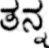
ತನ್ನ
